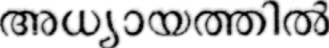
അധ്യായത്തില്‍
